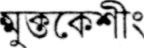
মুক্তকেশীং
